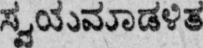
ಸ್ವಯಮಾಡಳಿತ
